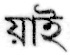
য়াই
